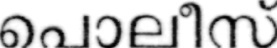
പൊലീസ്
